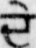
ਦੇ
